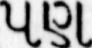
પણ
